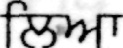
ਲਿਆ
